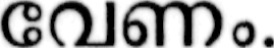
വേണം.
